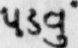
પડવું
